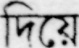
দিয়ে
